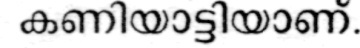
കണിയാട്ടിയാണ്.
